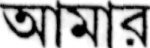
আমার
